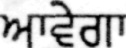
ਆਵੇਗਾ
